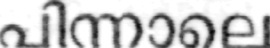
പിന്നാലെ
